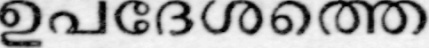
ഉപദേശത്തെ
